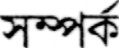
সম্পর্ক
